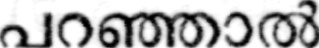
പറഞ്ഞാല്‍
